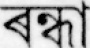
ৰন্ধা
